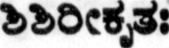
ಶಿಶಿರೀಕೃತಃ
